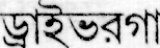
ড্রাইভরগা
